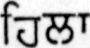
ਹਿਲਾ
